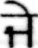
ਜੇ
